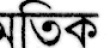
মতিক
